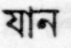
যান
